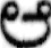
ಆ
